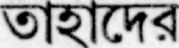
তাহাদের
